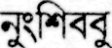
নুংশিববু
